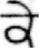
ਕੇ
